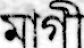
মাগী
